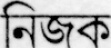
নিজক
